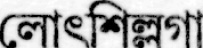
লোৎশিল্লগা
